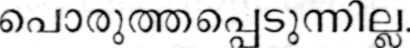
പൊരുത്തപ്പെടുന്നില്ല.
